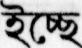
ইচ্ছে
